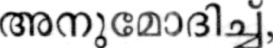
അനുമോദിച്ച്,
